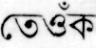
তেওঁক
